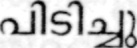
പിടിച്ചു
